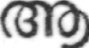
ആ
